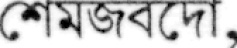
শেমজবদো,
